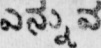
ಎನ್ನುವ
